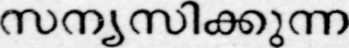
സന്യസിക്കുന്ന
